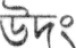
উদং
